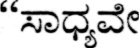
"ಸಾಧ್ಯವೇ
